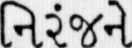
નિરંજને
